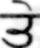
ਤੇ
